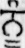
ਨੂੰ
